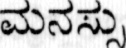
ಮನಸ್ಸು
